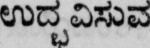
ಉದ್ಭವಿಸುವ
